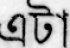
এটা
